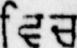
ਵਿਚ
